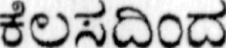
ಕೆಲಸದಿಂದ
